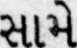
સામે
